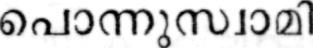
പൊന്നുസ്വാമി
